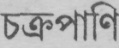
চক্ৰপাণি
